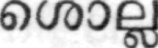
ശൊല്ല
